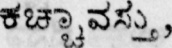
ಕಚ್ಚಾವಸ್ತು,
